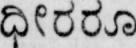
ಧೀರರೂ
